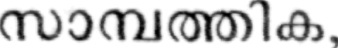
സാമ്പത്തിക,
